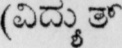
(ವಿದ್ಯುತ್
